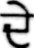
ਦੇ
